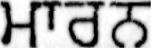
ਮਾਰਨ
